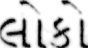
લોકો
